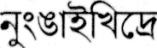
নুংঙাইখিদ্রে
